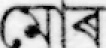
মোৰ
